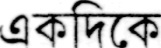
একদিকে
